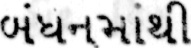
બંધનમાંથી
